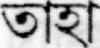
তাহা
